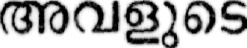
അവളുടെ
